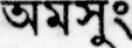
অমসুং
